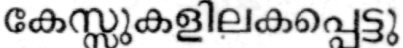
കേസ്സുകളിലകപ്പെട്ടു
